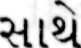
સાથે
